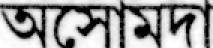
অসোমদা
